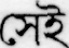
সেই
